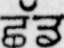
ਛੱਡ
